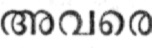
അവരെ
